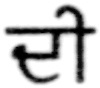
ਦੀ
